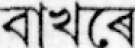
বাখৰে
